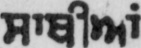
ਸਾਥੀਆਂ
